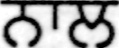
ਨਾਲ
